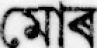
মোৰ
